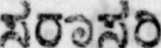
ಸರಾಸರಿ
